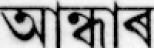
আন্ধাৰ
